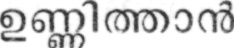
ഉണ്ണിത്താന്‍
